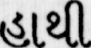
હાથી
